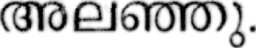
അലഞ്ഞു.
